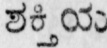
ಶಕ್ತಿಯ
